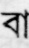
বা
